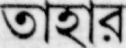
তাহার
